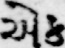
એક
